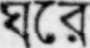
ঘরে
